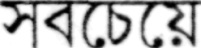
সবচেয়ে
